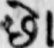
છો
